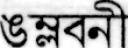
ঙম্লবনী
